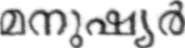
മനുഷ്യര്‍
